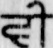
ਵੀ
